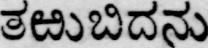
ತಱುಬಿದನು
